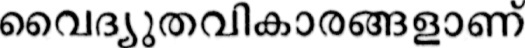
വൈദ്യുതവികാരങ്ങളാണ്
